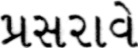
પ્રસરાવે
